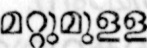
മറ്റുമുള്ള
